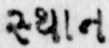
સ્થાન
